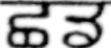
ਛਡ
